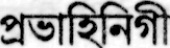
প্রভাহিনিগী
